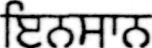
ਇਨਸਾਨ
